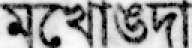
মখোঙদা
